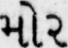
મોર
